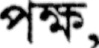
পক্ষ,
